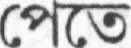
পেতে
